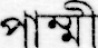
পাম্মী
